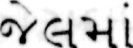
જેલમાં
